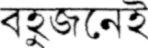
বহুজনেই
